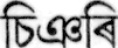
চিঞৰি
